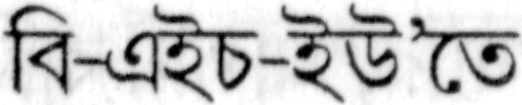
বি-এইচ-ইউ'তে
